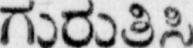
ಗುರುತಿಸಿ
